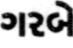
ગરબે
